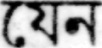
যেন
